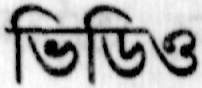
ভিডিও
